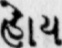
હોય
